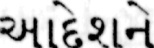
આદેશને
